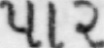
પાર
